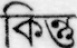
কিন্তু
